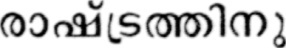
രാഷ്ട്രത്തിനു
